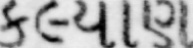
કલ્યાણ
